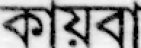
কায়বা
